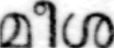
മീശ
